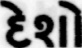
દેશો
